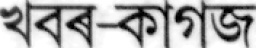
খবৰ-কাগজ
